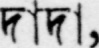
দাদা,
